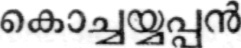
കൊച്ചയ്യപ്പന്‍
